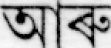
আৰু
